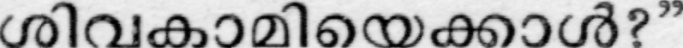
ശിവകാമിയെക്കാള്‍?''
